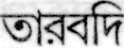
তারবদি
